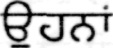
ਉਹਨਾਂ
